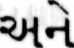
અને
